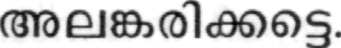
അലങ്കരിക്കട്ടെ.
